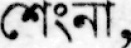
শেংনা,
